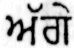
ਅੱਗੇ
